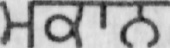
ਮਕਾਨ
